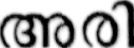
അരി
